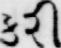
કરી
